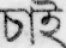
চাই
